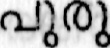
പുരു
